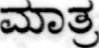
ಮಾತ್ರ
